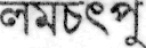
লমচৎপু
